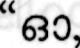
"ഓ,
